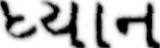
ધ્યાન
